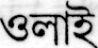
ওলাই
